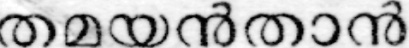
തമയന്‍താന്‍
